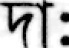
দা:
